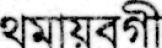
থমায়বগী
